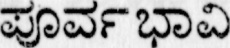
ಪೂರ್ವಭಾವಿ
